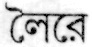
লৈরে
